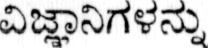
ವಿಜ್ಞಾನಿಗಳನ್ನು
